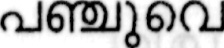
പഞ്ചുവെ
